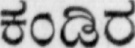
ಕಂಡಿರ
